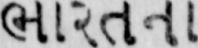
ભારતના
